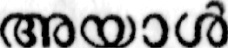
അയാള്‍
